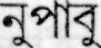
নুপাবু
